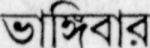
ভাঙ্গিবার
